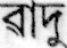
ৱাদু
